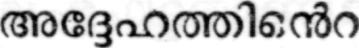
അദ്ദേഹത്തിന്റെ
